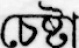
চেষ্টা
